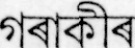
গৰাকীৰ
